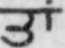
ਤਾਂ
